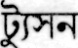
ট্যুসন
